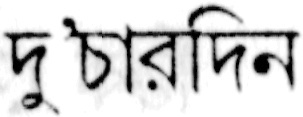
দু'চারদিন
